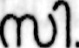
സി.
